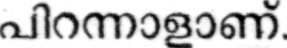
പിറന്നാളാണ്.
